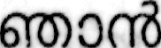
ഞാന്‍
